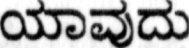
ಯಾವುದು
